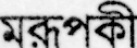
মরূপকী
